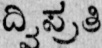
ದ್ವಿಪ್ರತಿ
